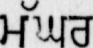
ਮੱਘਰ
